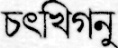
চৎখিগনু
